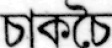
চাকচৈ
